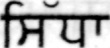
ਸਿੱਧਾ
